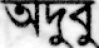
অদুবু
